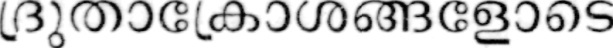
ദ്രുതാക്രോശങ്ങളോടെ
